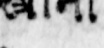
સ્ત્રીના
